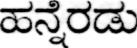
ಹನ್ನೆರಡು
